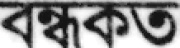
বন্ধকত
